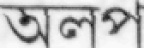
অলপ
